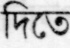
দিতে
